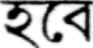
হবে
